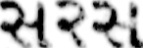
સરસ
